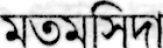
মতমসিদা
